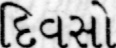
દિવસો
